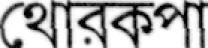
থোরকপা
